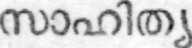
സാഹിത്യ
